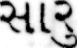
સારુ
